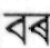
বৰ
